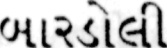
બારડોલી
